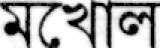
মখোল
